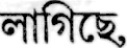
লাগিছে,
